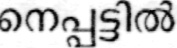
നെപ്പട്ടില്‍
